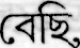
বেছি,
